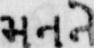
મનને
